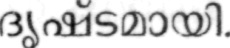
ദൃഷ്ടമായി.
